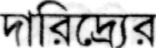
দারিদ্র্যের
